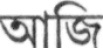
আজি
